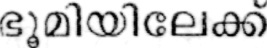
ഭൂമിയിലേക്ക്
